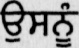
ਉਸਨੂੰ
